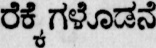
ರೆಕ್ಕೆಗಳೊಡನೆ
